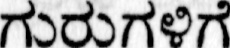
ಗುರುಗಳಿಗೆ
